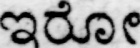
ಇರೋ
